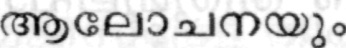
ആലോചനയും
